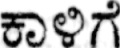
ಕಾಳಿಗೆ
